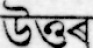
উত্তৰ
